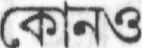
কোনও
